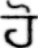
ਹੋ
